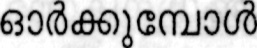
ഓര്‍ക്കുമ്പോള്‍
